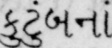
કુટુંબનાં
